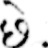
છે.
